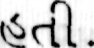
હતી.
